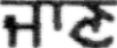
ਜਾਣ
